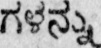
ಗಳನ್ನು
